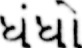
ધંધો
